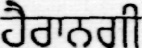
ਹੈਰਾਨਗੀ
